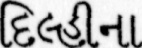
દિલ્હીના
